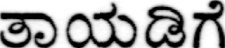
ತಾಯಡಿಗೆ
